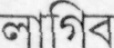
লাগিব
